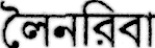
লৈনরিবা
